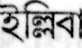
ইল্লিবা
